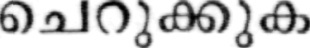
ചെറുക്കുക
